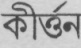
কীৰ্ত্তন
